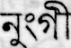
নুংগী
